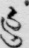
હું
